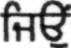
ਜਿਉਂ
